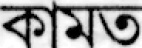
কামত
